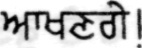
ਆਖਣਗੇ!
